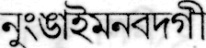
নুংঙাইমনবদগী
